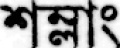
শম্লাং
